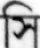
সি
